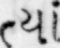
ત્યાં
